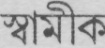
স্বামীক
